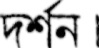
দর্শন।
